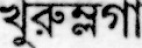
খুরুম্লগা
